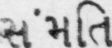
સંમતિ
